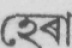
হেৰা
